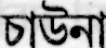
চাউনা
